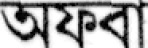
অফবা
